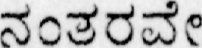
ನಂತರವೇ
